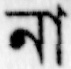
না
